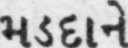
મડદાને
